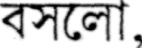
বসলো,
